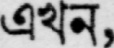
এখন,
